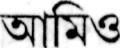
আমিও
